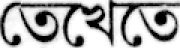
তেখেতে
